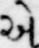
એ
